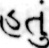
હતું
